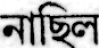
নাছিল
